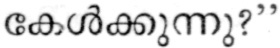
കേള്‍ക്കുന്നു?"
